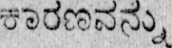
ಕಾರಣವನ್ನು
